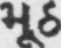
મૂઠ
